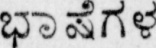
ಭಾಷೆಗಳ
